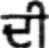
ਦੀ
